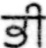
ਭੀ
